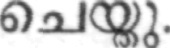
ചെയ്തു.
